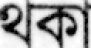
থকা
